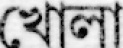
খোলা
